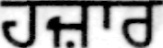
ਹਜ਼ਾਰ
